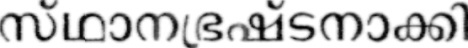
സ്ഥാനഭ്രഷ്ടനാക്കി
